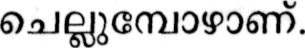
ചെല്ലുമ്പോഴാണ്.
